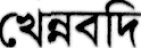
খেন্নবদি
